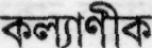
কল্যাণীক
